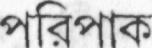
পরিপাক
